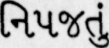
નિપજતું
